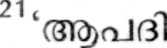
21'ആപദി
